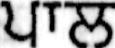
ਪਾਲ
